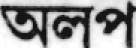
অলপ
